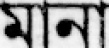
মানা
